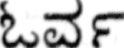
ಓರ್ವ
